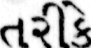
તરીકે
